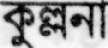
কুল্লনা
